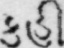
કહી
